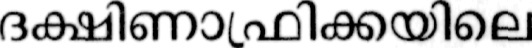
ദക്ഷിണാഫ്രിക്കയിലെ
